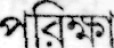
পরিক্ষা
